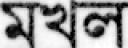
মখল
